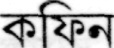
কফিন
